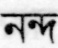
নন্দ
